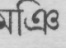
মঞি
